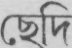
ছেদি
